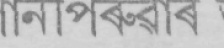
পানীপৰুৱাৰ
